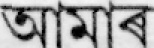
আমাৰ
